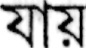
যায়
